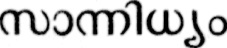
സാന്നിധ്യം
